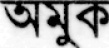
অমুক
